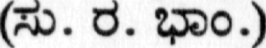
(ಸು.ರ.ಭಾಂ)
